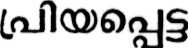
പ്രിയപ്പെട്ട
